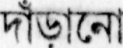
দাঁড়ানো
